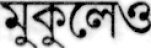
মুকুলেও
